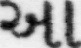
આ
